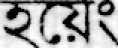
হয়েং
